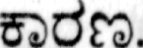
ಕಾರಣ.
